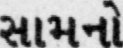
સામનો
